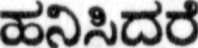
ಹನಿಸಿದರೆ
